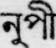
নুপী
